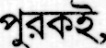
পুরকই,
